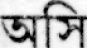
অসি
